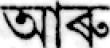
আৰু
